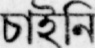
চাইনি
